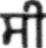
ਸੀ
